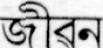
জীৱন
